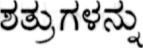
ಶತ್ರುಗಳನ್ನು
